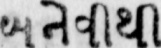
બનેવીથી
